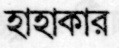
হাহাকার
